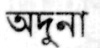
অদুনা
